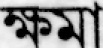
ক্ষমা
